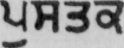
ਪੁਸਤਕ
